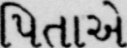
પિતાએ
